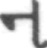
ન
